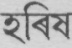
হৰিষ
